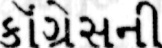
કૉંગ્રેસની
